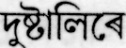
দুষ্টালিৰে
